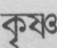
কৃষ্ণ
